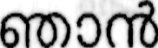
ഞാന്‍
